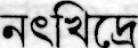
নৎখিদ্রে
